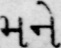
મને
